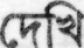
দেখি
